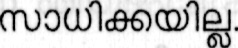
സാധിക്കയില്ല.
